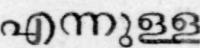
എന്നുള്ള
